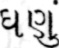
ઘણું
